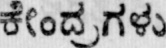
ಕೇಂದ್ರಗಳು
